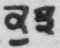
ਕੁਝ
